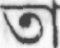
তা
